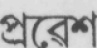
প্রৱেশ
